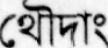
থৌদাং
